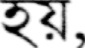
হয়,
